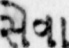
સેવા
